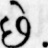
છે.
